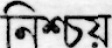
নিশ্চয়
